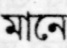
মানে
